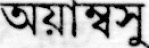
অয়াম্বসু
